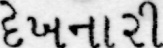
દેખનારી
